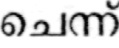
ചെന്ന്
